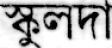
স্কুলদা
